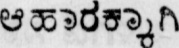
ಆಹಾರಕ್ಕಾಗಿ
